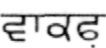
ਵਾਕਫ਼
